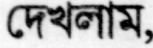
দেখলাম,
